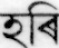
হৰি
